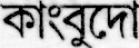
কাংবুদো
